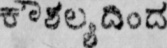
ಕೌಶಲ್ಯದಿಂದ
